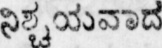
ನಿಶ್ಚಯವಾದ
